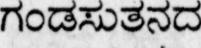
ಗಂಡಸುತನದ
